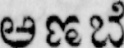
ಅಣಬೆ
